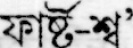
ফাৰ্ষ্ট-শ্ব'
